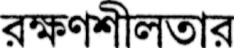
রক্ষণশীলতার
